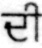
ਦੀ
